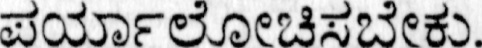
ಪರ್ಯಾಲೋಚಿಸಬೇಕು.
